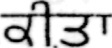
ਕੀਤਾ
